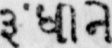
રૂંધીને
